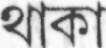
থাকা
